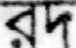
রদ
